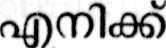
എനിക്ക്
